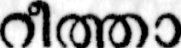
റീത്താ
